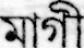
মাগী
